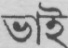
ভাই
